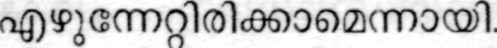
എഴുന്നേറ്റിരിക്കാമെന്നായി.
